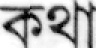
কথা
